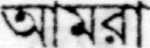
আমরা
